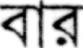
বার
